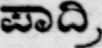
ಪಾದ್ರಿ
